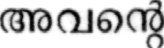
അവന്റെ
